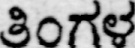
ತಿಂಗಳ
